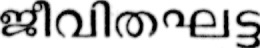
ജീവിതഘട്ട
